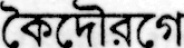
কৈদৌরগে
